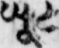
બૂટ
